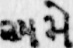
અમે
